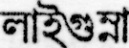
লাইগুম্না
